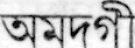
অমদগী
